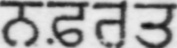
ਨਫ਼ਰਤ
